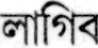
লাগিব
